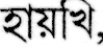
হায়খি,
